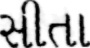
સીતા
